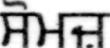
ਸੋਮਜ਼
